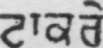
ਟਾਕਰੇ
